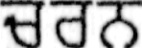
ਚਰਨ
